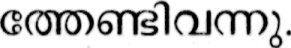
ത്തേണ്ടിവന്നു.
